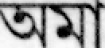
অমা
